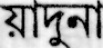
য়াদুনা
